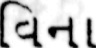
વિના
